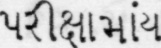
પરીક્ષામાંય
